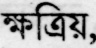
ক্ষত্রিয়,
